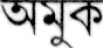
অমুক
